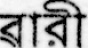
ৱারী
